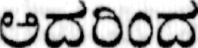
ಅದರಿಂದ
